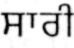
ਸਾਰੀ
